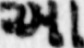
આ
